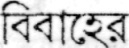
বিবাহের
